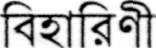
বিহারিণী
